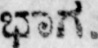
ಭಾಗ.
